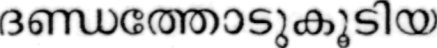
ദണ്ഡത്തോടുകൂടിയ
